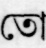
তো
